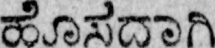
ಹೊಸದಾಗಿ
